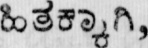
ಹಿತಕ್ಕಾಗಿ,
